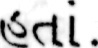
હતાં.
